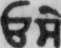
ਓਸੇ
